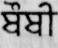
ਬੌਬੀ
